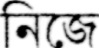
নিজে
